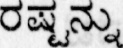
ರಷ್ಟನ್ನು
